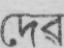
দেৱ
